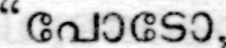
“പോടോ,
